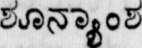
ಶೂನ್ಯಾಂಶ
